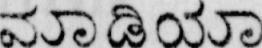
ಮಾಡಿಯಾ
